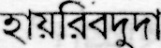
হায়রিবদুদা
